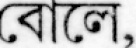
বোলে,
